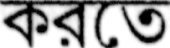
করতে
